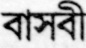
বাসবী
